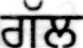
ਗੱਲ
